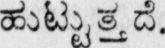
ಹುಟ್ಟುತ್ತದೆ.
